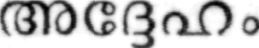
അദ്ദേഹം
